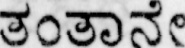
ತಂತಾನೇ
